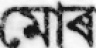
মোৰ
